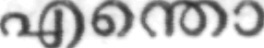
എന്തൊ
